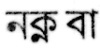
নক্নবা
